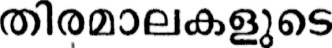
തിരമാലകളുടെ
